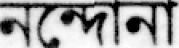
নন্দোনা
